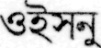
ওইসনু
